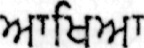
ਆਖਿਆ
